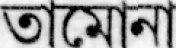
তামোনা
